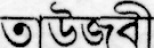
তাউজবী
